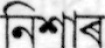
নিশাৰ
